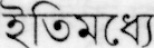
ইতিমধ্যে
